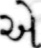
એ
